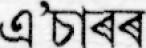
এ'চাৰৰ
